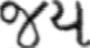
જય
